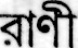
রাণী
